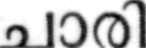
ചാരി
